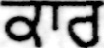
ਕਾਰ
